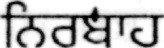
ਨਿਰਬਾਹ
